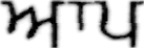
ਆਪ
